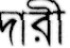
দারী
